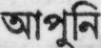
আপুনি
